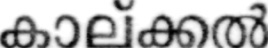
കാല്ക്കല്‍
